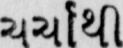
ચર્ચાથી
